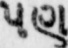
પણ
